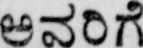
ಅವರಿಗೆ
